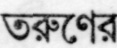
তরুণের
